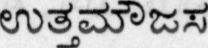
ಉತ್ತಮೌಜಸ
